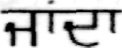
ਜਾਂਦਾ
